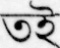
তই
